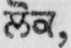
ਲੋਕ,
